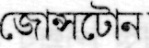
জোন্সটোন
